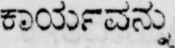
ಕಾರ್ಯವನ್ನು
